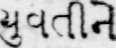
યુવતીને
